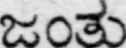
ಜ೦ತು
